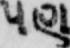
પણ
